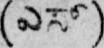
(ಎಸ್)
